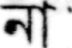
না
